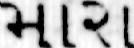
મારા
